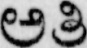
ಅತಿ
